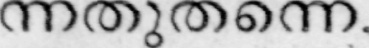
ന്നതുതന്നെ.
